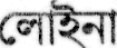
লোইনা
